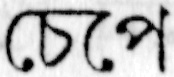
চেপে
